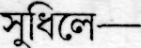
সুধিলে-
